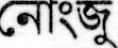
নোংজু
